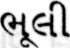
ભૂલી
